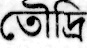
তৌদ্রি
